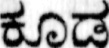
ಕೂಡ
